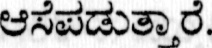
ಆಸೆಪಡುತ್ತಾರೆ.
